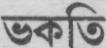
ভকতি
